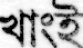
খাংই
